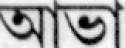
আভা
